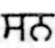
ਸਨ
